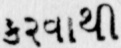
કરવાથી
